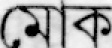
মোক
